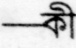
–কী
